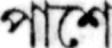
পাশে
